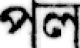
পল
